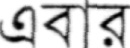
এবার
